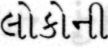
લોકોની
